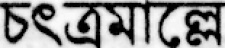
চৎত্রমাল্লে
